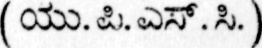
(ಯು.ಪಿ.ಎಸ್.ಸಿ)
